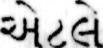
એટલે
